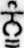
ਨੂੰ
